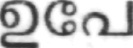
ഉപേ
